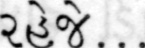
રહેજે...
